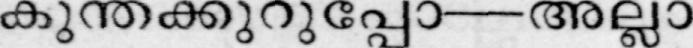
കുന്തക്കുറുപ്പോ-അല്ലാ
